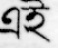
এই
